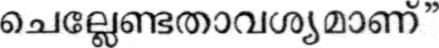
ചെല്ലേണ്ടതാവശ്യമാണ്”
